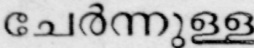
ചേര്‍ന്നുള്ള
